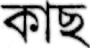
কাছ
